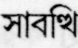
সাবত্থি
